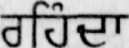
ਰਹਿੰਦਾ
